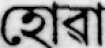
হোৱা
